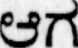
ಆಗ
